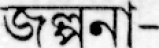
জল্পনা-
